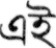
এই
